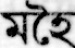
মহৈ
